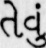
તેવું
